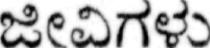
ಜೀವಿಗಳು
